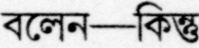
বলেন–কিন্তু
